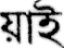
য়াই
